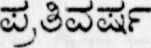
ಪ್ರತಿವರ್ಷ
